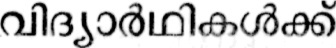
വിദ്യാര്‍ഥികള്‍ക്ക്
